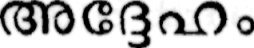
അദ്ദേഹം
